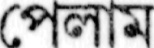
পেলাম
